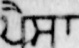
ਪੈਸਾ
